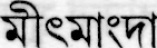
মীৎমাংদা
